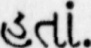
હતાં.
